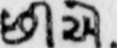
છીએ.
